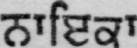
ਨਾਇਕਾ
